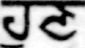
ਹੁਣ
